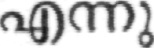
എന്നു
